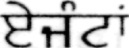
ਏਜੰਟਾਂ
